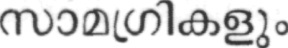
സാമഗ്രികളും
